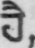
ਹੈ,
